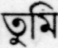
তুমি
